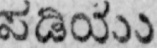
ಪಡಿಯು
